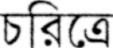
চরিত্রে
